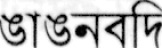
ঙাঙনবদি
